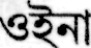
ওইনা
